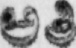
ಅತಿ
